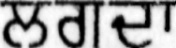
ਲਗਦਾ
